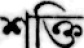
শক্তি
